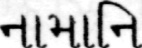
નામાનિ
